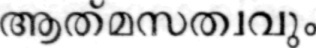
ആത്മസത്വവും
